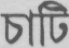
চাটি
